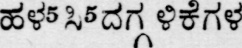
ಹಳ5ಸಿ5ದಗ್ಗಳಿಕೆಗಳ
